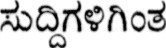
ಸುದ್ದಿಗಳಿಗಿಂತ
